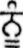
ਨੂੰ
